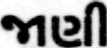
જાણી
